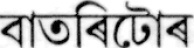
বাতৰিটোৰ
